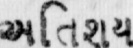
અતિશય
